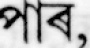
পাৰ,
